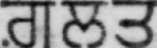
ਗ਼ਲਤ
